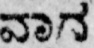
ವಾದ
